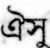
ঐসু
